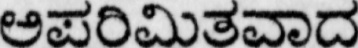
ಅಪರಿಮಿತವಾದ
